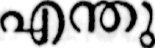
എന്തു
